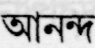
আনন্দ
